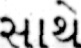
સાથે
